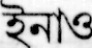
ইনাও
